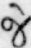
જે
